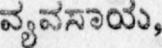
ವ್ಯವಸಾಯ,
